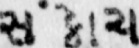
સંકોચ
